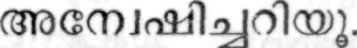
അന്വേഷിച്ചറിയൂ.
